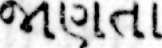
જાણતા
